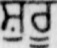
ਸ਼ੁਰੂ
